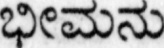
ಭೀಮನು
